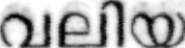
വലിയ
